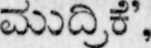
ಮುದ್ರಿಕೆ’,
